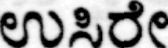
ಉಸಿರೇ
